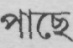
পাছে
